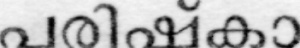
പരിഷ്കാ
